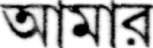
আমার
